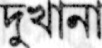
দুখানা
